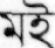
মই
